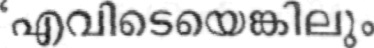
‘എവിടെയെങ്കിലും
